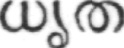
ധൃത
